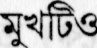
মুখটিও
